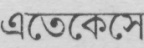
এতেকেসে
